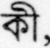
কী,
